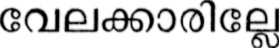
വേലക്കാരില്ലേ
